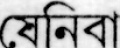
ষেনিবা
